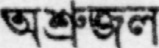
অশ্রুজল
